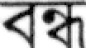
বন্ধ
